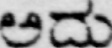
ಅದು
